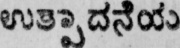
ಉತ್ಪಾದನೆಯ
